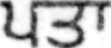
ਪਤਾ
